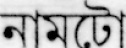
নামটো
